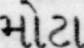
મોટા
